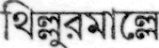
থিল্লুরমাল্লে
